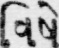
વિષે
